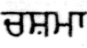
ਚਸ਼ਮਾ
